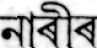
নাৰীৰ
